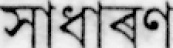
সাধাৰণ
